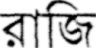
রাজি
